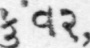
કુંવર,
